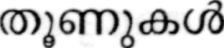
തൂണുകള്‍
